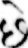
છે
